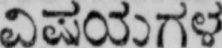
ವಿಷಯಗಳ
